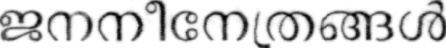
ജനനീനേത്രങ്ങള്‍
